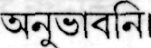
অনুভাবনি।
